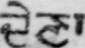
ਦੇਣਾ
